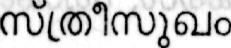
സ്ത്രീസുഖം
